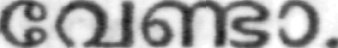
വേണ്ടാ.
